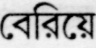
বেরিয়ে
